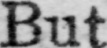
But
